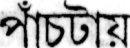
পাঁচটায়
